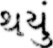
થયું
